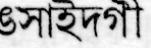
ঙসাইদগী
